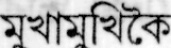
মুখামুখিকৈ
